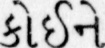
કોઈને
